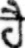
ਹੈ
